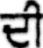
ਦੀ
